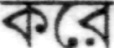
করে
